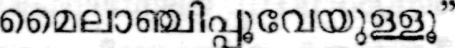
മൈലാഞ്ചിപ്പൂവേയുള്ളൂ”
